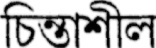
চিন্তাশীল
